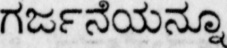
ಗರ್ಜನೆಯನ್ನೂ
